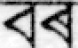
বৰ
